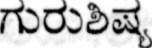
ಗುರುಶಿಷ್ಯ
